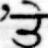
'ਤੇ
